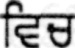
ਵਿਚ
